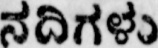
ನದಿಗಳು
